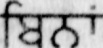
ਬਿਨਾਂ
